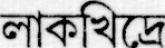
লাকখিদ্রে
